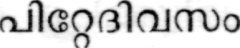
പിറ്റേദിവസം
